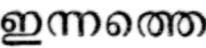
ഇന്നത്തെ
